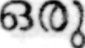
ഒരു
